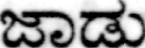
ಜಾಡು
